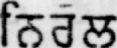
ਨਿਰੋਲ
